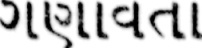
ગણાવતા
